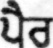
ਪੈਰ
